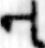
ન
